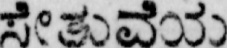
ಸೇತುವೆಯ
